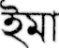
ইমা
